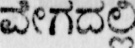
ವೇಗದಲ್ಲಿ
